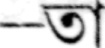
-তা
